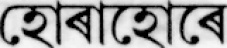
হোৰাহোৰে
